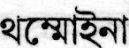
থম্মোইনা
